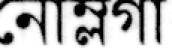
নোম্লগা
